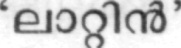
'ലാറ്റിന്‍'
